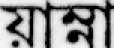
য়াম্না
